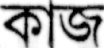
কাজ
